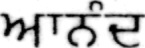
ਆਨੰਦ
